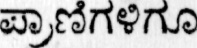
ಪ್ರಾಣಿಗಳಿಗೂ
